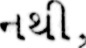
નથી,
